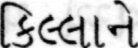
કિલ્લાને
